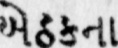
બેઠકના
